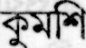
কুমশি
